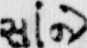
સાંજે
